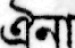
ঐনা
